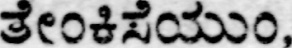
ತೇಂಕಿಸೆಯುಂ,
